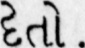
દેતો.
